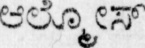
ಆಲ್ಮೋಸ್
